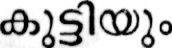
കുട്ടിയും
